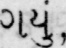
ગયું,
